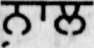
ਨਾਲ
